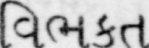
વિભક્ત
